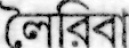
লৈরিবা
